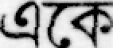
একে
